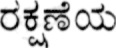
ರಕ್ಷಣೆಯ
